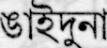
ঙাইদুনা
